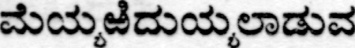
ಮೆಯ್ಯಱೆದುಯ್ಯಲಾಡುವ
